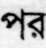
পর
